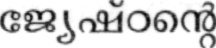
ജ്യേഷ്ഠന്റെ
